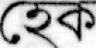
হেক
